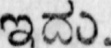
ಇದು.
